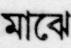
মাঝে
